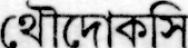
থৌদোকসি
